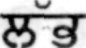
ਲੱਭ
